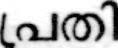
പ്രതി
